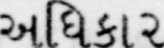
અધિકાર
